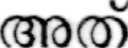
അത്
